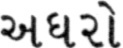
અધરો
